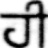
ਹੀ
